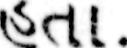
હતા.
